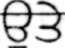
ਉਤੇ
